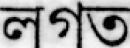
লগত
